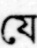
যে
